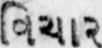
વિચાર
